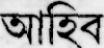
আহিব
